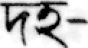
দহ-
